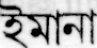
ইমানা
